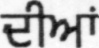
ਦੀਆਂ
